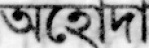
অহোদা
